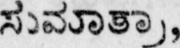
ಸುಮಾತ್ರಾ,
